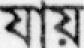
যায়
